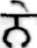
ਨੇ
